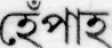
হেঁপাহ
